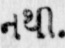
નથી.
